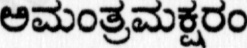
ಅಮಂತ್ರಮಕ್ಷರ೦
